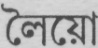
লৈয়ো
